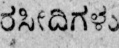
ರಸೀದಿಗಳು
